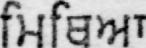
ਮਿਥਿਆ
